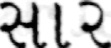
સાર
